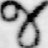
જ
